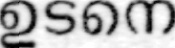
ഉടനെ
